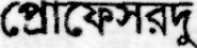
প্রোফেসরদু
